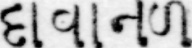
દાવાનળ
